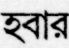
হবার
